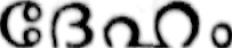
ദേഹം
